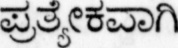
ಪ್ರತ್ಯೇಕವಾಗಿ
